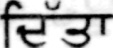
ਦਿੱਤਾ
